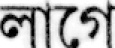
লাগে
